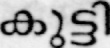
കുട്ടി
